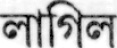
লাগিল
